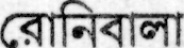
রোনিবালা
